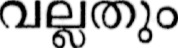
വല്ലതും
